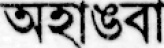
অহাঙবা
